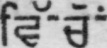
ਵਿੱਚੋਂ
